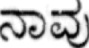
ನಾವು
